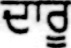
ਦਾਰੂ
